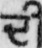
ਦੀ
